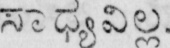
ಸಾಧ್ಯವಿಲ್ಲ.
